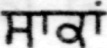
ਸਾਕਾਂ
